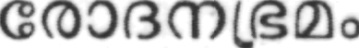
രോദനഭ്രമം
